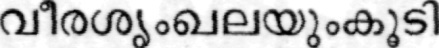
വീരശൃംഖലയുംകൂടി
